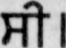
ਸੀ।
